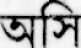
অসি
